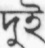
দুই
